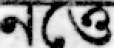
নত্তে
